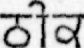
ਠੀਕ
